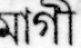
মাগী
